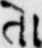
તો
